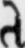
તે
